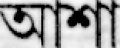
আশা
